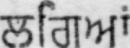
ਲਗਿਆਂ
